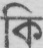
কি
